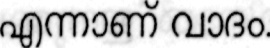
എന്നാണ്വാദം.
